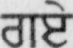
ਗਏ
